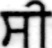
ਸੀ
